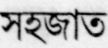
সহজাত
